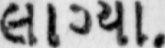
લાગ્યા,
